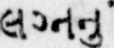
લગ્નનું
